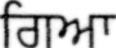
ਗਿਆ
